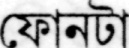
ফোনটা
